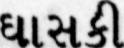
ઘાસકી
